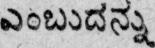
ಎಂಬುದನ್ನು
